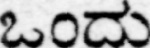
ಒಂದು
